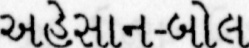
અહેસાન-બોલ
